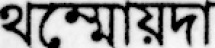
থম্মোয়দা
